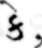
કે,
